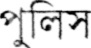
পুলিস
